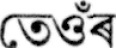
তেওঁৰ
